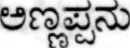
ಅಣ್ಣಪ್ಪನು
